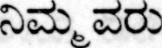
ನಿಮ್ಮವರು
